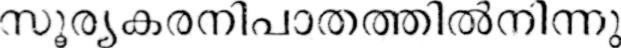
സൂര്യകരനിപാതത്തില്‍നിന്നു
